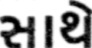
સાથે
